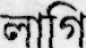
লাগি
